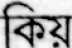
কিয়
